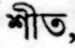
শীত,
